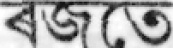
ৰজতে
